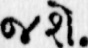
જશે.
